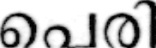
പെരി
